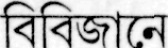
বিবিজানে
